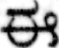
ಈ
